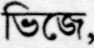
ভিজে,
